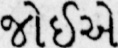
જોઈએ
